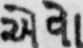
એવો
